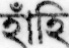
হাঁহি
